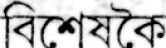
বিশেষকৈ
